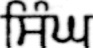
ਸਿੰਘ
